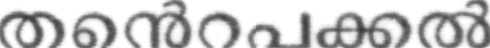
തന്റെപക്കല്‍
